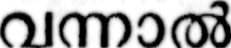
വന്നാല്‍
